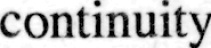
continuity
